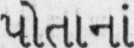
પોતાનાં
